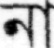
না
